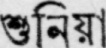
শুনিয়া
